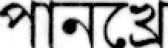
পানখ্রে
